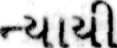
ન્યાયી
